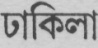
ঢাকিলা
